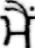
ਮੈਂ
